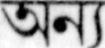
অন্য
